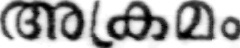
അക്രമം
